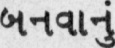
બનવાનું
